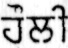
ਹੌਲੀ
